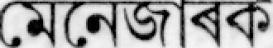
মেনেজাৰক
